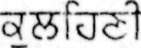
ਕੁਲਹਿਣੀ
